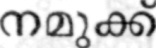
നമുക്ക്
